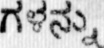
ಗಳನ್ನು
